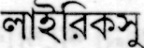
লাইরিকসু
